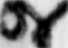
જ
